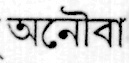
অনৌবা
